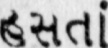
હસતાં
